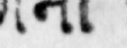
છાના
